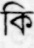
কি
